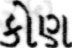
કોણ
